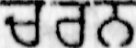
ਚਰਨ
